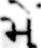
મેં
